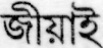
জীয়াই
